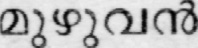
മുഴുവന്‍
